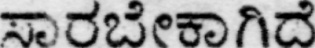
ಸಾರಬೇಕಾಗಿದೆ
